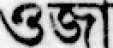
ওজা
